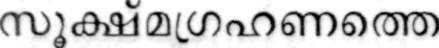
സൂക്ഷ്മഗ്രഹണത്തെ
